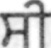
ਸੀ
